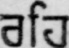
ਰਹਿ
